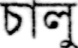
চালু
